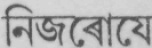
নিজৰোযে
